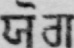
ਯੋਗ
